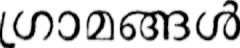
ഗ്രാമങ്ങള്‍
